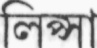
লিপ্সা
